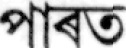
পাৰত
